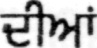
ਦੀਆਂ
